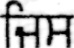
ਜਿਸ
